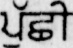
ਪੁੱਛੀ
